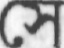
সে
